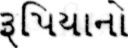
રૂપિયાનો
